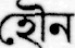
হৌন
